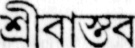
শ্রীবাস্তব
